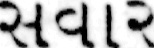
સવાર
